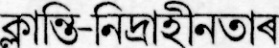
ক্লান্ত-নিদ্রাহীনতাৰ
